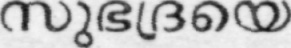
സുഭദ്രയെ
